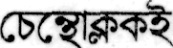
চেন্থোক্লকই
